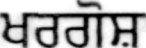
ਖਰਗੋਸ਼
